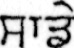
ਸਾਡੇ
